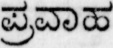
ಪ್ರವಾಹ
